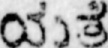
ಯತೆ
